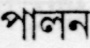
পালন
